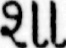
શા
